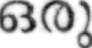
ഒരു
